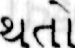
થતો
